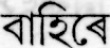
বাহিৰে
